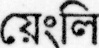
য়েংলি
